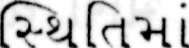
સ્થિતિમાં
